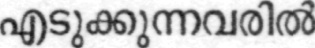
എടുക്കുന്നവരില്‍
